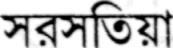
সরসতিয়া
